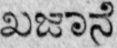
ಖಜಾನೆ
